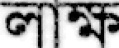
লাক্ষ
